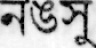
নঙসু
